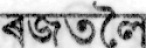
ৰজতলৈ
